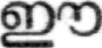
ഈ
